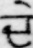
ਦੇ
